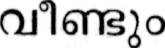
വീണ്ടും
